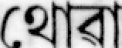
থোৱা
